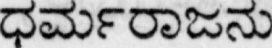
ಧರ್ಮರಾಜನು
